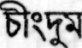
চীংদুম
